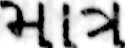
માત્ર
